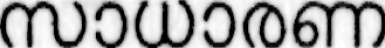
സാധാരണ
